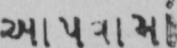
આપવામાં
